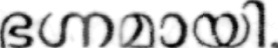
ഭഗ്നമായി.
